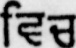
ਵਿਚ
